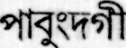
পাবুংদগী
